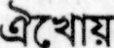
ঐখোয়
